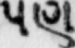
પણ
